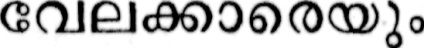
വേലക്കാരെയും
